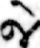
જે
